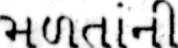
મળતાંની
